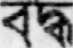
বদ্ধ
